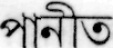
পানীত
